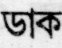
ডাক
